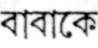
বাবাকে
